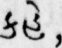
કહે,
